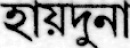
হায়দুনা
